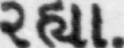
રહ્યા.
